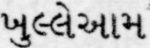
ખુલ્લેઆમ
